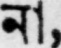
না,
